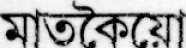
মাতকৈয়ো
